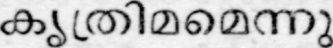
കൃത്രിമമെന്നു
